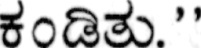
ಕಂಡಿತು."
